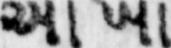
આખા
